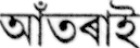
আঁতৰাই
